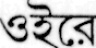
ওইরে
